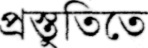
প্রস্তুতিতে
